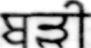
ਬੜੀ
